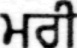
ਮਰੀ
